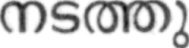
നടത്തു
